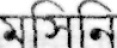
মসিনি
